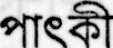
পাৎকী
